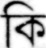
কি
